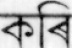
কৰি
